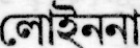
লোইননা
